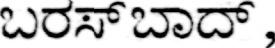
ಬರಸ್ ಬಾದ್,
